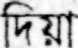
দিয়া
